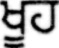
ਖੂਹ
